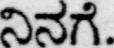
ನಿನಗೆ.
